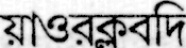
য়াওরক্লবদি
